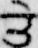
ਤੇ
